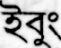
ইবুং
